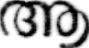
ആ
